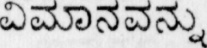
ವಿಮಾನವನ್ನು
